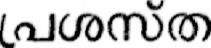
പ്രശസ്ത
